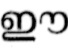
ഈ
